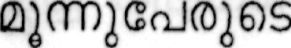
മൂന്നുപേരുടെ
